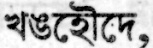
খঙহৌদে,
